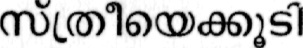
സ്ത്രീയെക്കൂടി
